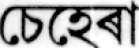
চেহেৰা
